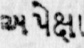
અપેક્ષા
